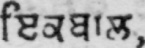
ਇਕਬਾਲ,
